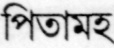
পিতামহ
